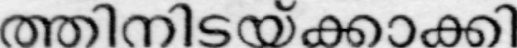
ത്തിനിടയ്ക്കാക്കി
